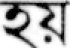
হয়
